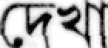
দেখা
